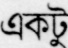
একটু
